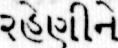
રહેણીને
